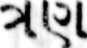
ત્રણ
